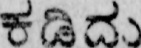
ಕಡಿದು
